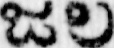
ಜಲ
